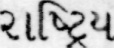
રાષ્ટ્રિય
